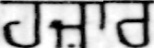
ਹਜ਼ਾਰ
